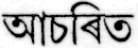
আচৰিত
